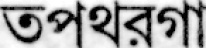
তপথরগা
